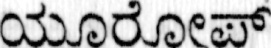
ಯೂರೋಪ್
